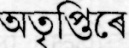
অতৃপ্তিৰে
